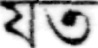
যত
